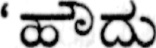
'ಹೌದು
